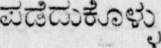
ಪಡೆದುಕೊಳ್ಳು
